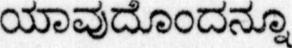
ಯಾವುದೊಂದನ್ನೂ
